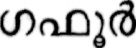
ഗഫൂര്‍
